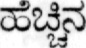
ಹೆಚ್ಚಿನ
